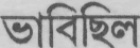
ভাবিছিল
